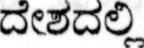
ದೇಶದಲ್ಲಿ
